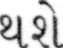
થશે
